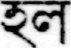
হল
